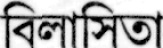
বিলাসিতা
